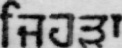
ਜਿਹੜਾ
